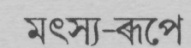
মৎস্য-ৰূপে
